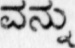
ವನ್ನು
